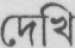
দেখি
